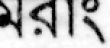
মরাং
